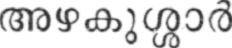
അഴകുശ്ശാര്‍
